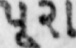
પૂરા
